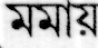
মমায়
